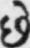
છે
